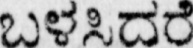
ಬಳಸಿದರೆ
